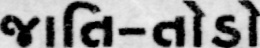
જાતિ-તોડો
